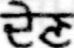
ਦੇਣ
